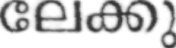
ലേക്കു
